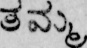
ತಮ್ಮ
